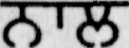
ਨਾਲ
